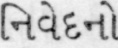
નિવેદનો
